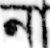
না
